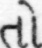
તો
